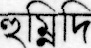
হুম্নিদি
